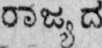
ರಾಜ್ಯದ
